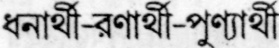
ধনার্থী-রণার্থী-পুণ্যার্থী
